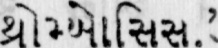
થ્રોમ્બોસિસ.'
